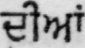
ਦੀਆਂ
